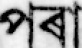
পৰা
